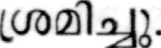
ശ്രമിച്ചു.
